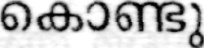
കൊണ്ടു
